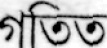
গতিত
